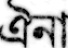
ঐনা
